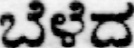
ಬೆಳೆದ
